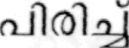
പിരിച്ച്
